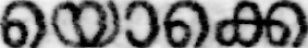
യൊക്കെ
